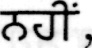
ਨਹੀਂ,
